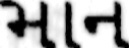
માન
